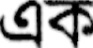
এক
